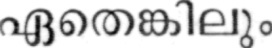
ഏതെങ്കിലും
